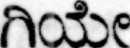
ಗಿಯೇ
